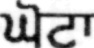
ਘੋਟਾ
